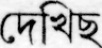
দেখিছ
